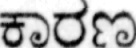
ಕಾರಣ
